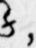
કે,
